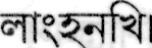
লাংহনখি।
